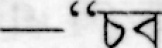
-"চব
